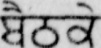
ਬੈਠਕੇ
